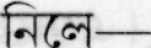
নিলে-
